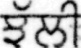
ਝੱਲੀ
